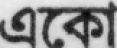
একো
